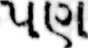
પણ
